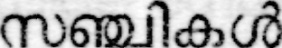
സഞ്ചികള്‍
